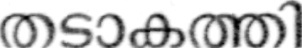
തടാകത്തി
